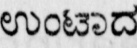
ಉಂಟಾದ
